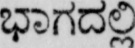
ಭಾಗದಲ್ಲಿ
